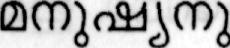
മനുഷ്യനു
